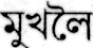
মুখলৈ
